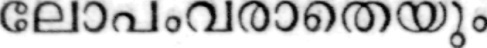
ലോപംവരാതെയും
